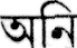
অনি
